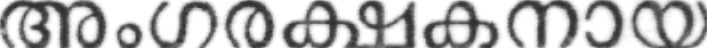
അംഗരക്ഷകനായ
